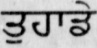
ਤੁਹਾਡੇ
